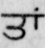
ਤਾਂ
